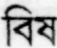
বিষ
